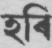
হৰি
